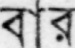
বার
